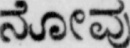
ನೋವು
